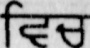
ਵਿਚ
